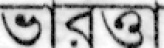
ভারত্তা
